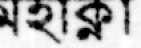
মহাক্না
